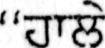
''ਹਾਲੇ
